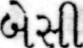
બેસી
